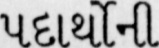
પદાર્થોની
